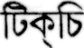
টিক্‌চি
